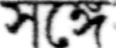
সঙ্গে
